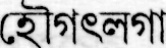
হৌগৎলগা
